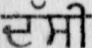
ਦੱਸੀ
